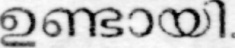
ഉണ്ടായി.
